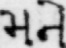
મને
